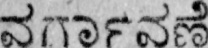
ವರ್ಗಾವಣೆ
